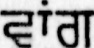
ਵਾਂਗ
